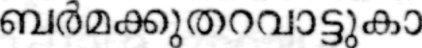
ബര്‍മക്കുതറവാട്ടുകാ
